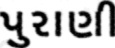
પુરાણી
